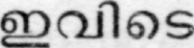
ഇവിടെ
